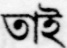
তাই
